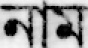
নাম
